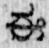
ಈ
